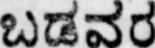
ಬಡವರ
